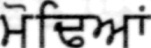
ਮੋਢਿਆਂ
